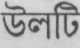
উলটি
